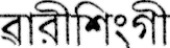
ৱারীশিংগী
